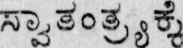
ಸ್ವಾತಂತ್ರ್ಯಕ್ಕೆ
